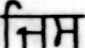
ਜਿਸ
